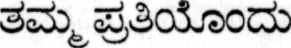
ತಮ್ಮಪ್ರತಿಯೊಂದು
